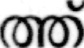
ത്ത്
